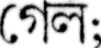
গেল;
